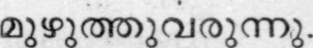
മുഴുത്തുവരുന്നു.
